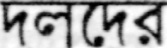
দলদের
